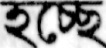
হচ্ছে
